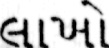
લાખો
